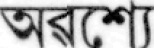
অৱশ্যে
